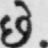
છે.
